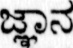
ಜ್ಞಾನ
